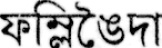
ফম্লিঙৈদা
